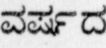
ವರ್ಷದ
